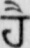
ਹੈ
